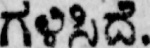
ಗಳಿಸಿದೆ.
